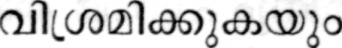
വിശ്രമിക്കുകയും
